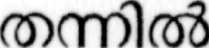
തന്നില്‍
